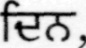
ਦਿਨ,
